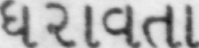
ધરાવતા
